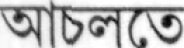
আচলতে
